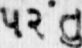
પરંતુ
